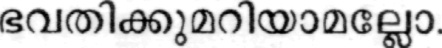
ഭവതിക്കുമറിയാമല്ലോ.
